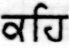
ਕਹਿ
